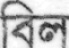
বিল
